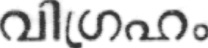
വിഗ്രഹം
